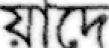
য়াদে
